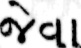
જેવા
